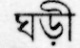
ঘড়ী
